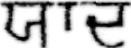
ਯਾਦ
